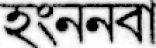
হংননবা
